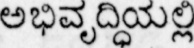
ಅಭಿವೃದ್ಧಿಯಲ್ಲಿ
